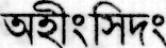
অহীংসিদং
